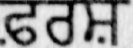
ਫ਼ਰਸ਼
